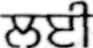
ਲਈ
